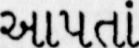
આપતાં
